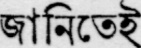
জানিতেই
